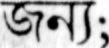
জন্য;
